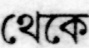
থেকে
